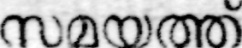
സമയത്ത്
